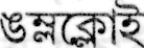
ঙম্লক্লোই
